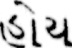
હોય
